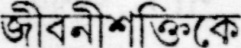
জীবনীশক্তিকে
